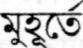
মুহূর্তে
